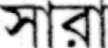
সারা
